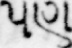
પણ
